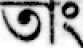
তাং
